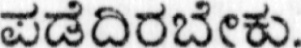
ಪಡೆದಿರಬೇಕು.
